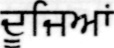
ਦੂਜਿਆਂ
